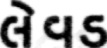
લેવડ
